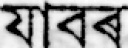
যাবৰ
